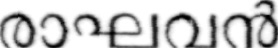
രാഘവന്‍
